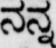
ನನ್ನ
